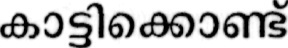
കാട്ടിക്കൊണ്ട്
